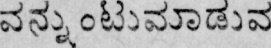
ವನ್ನುಂಟುಮಾಡುವ
